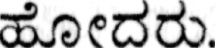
ಹೋದರು.
